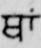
ਥਾਂ
